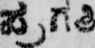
ಪ್ರಗತಿ
